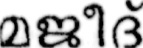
മജീദ്
